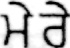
ਮੇਰੇ
